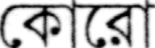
কোরো
